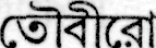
তৌবীরো
